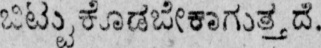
ಬಿಟ್ಟುಕೊಡಬೇಕಾಗುತ್ತದೆ.
